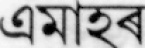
এমাহৰ
